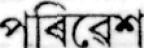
পৰিৱেশ
